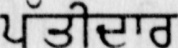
ਪੱਤੀਦਾਰ
